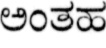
ಅಂತಹ
